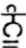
ਨੂੰ
